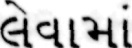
લેવામાં
